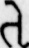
તે
